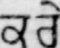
ਕਰੇ
